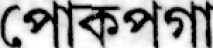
পোকপগা
